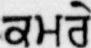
ਕਮਰੇ
